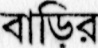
বাড়ির
